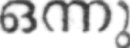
ഒന്നു
